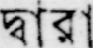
দ্বারা
